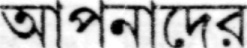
আপনাদের
